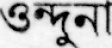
ওন্দুনা
